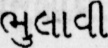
ભુલાવી
